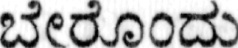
ಬೇರೊಂದು
